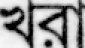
খরা
